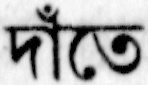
দাঁতে
